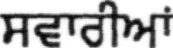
ਸਵਾਰੀਆਂ
